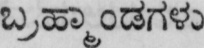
ಬ್ರಹ್ಮಾಂಡಗಳು
